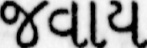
જવાય
